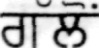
ਗੱਲੋਂ
